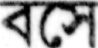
বসে
